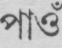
পাওঁ
